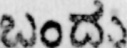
ಬಂದು
